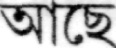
আছে
